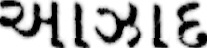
આઝાદ
